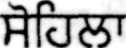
ਸੋਹਿਲਾ
